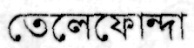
তেলেফোন্দা
